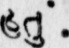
હતું.
